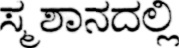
ಸ್ಮಶಾನದಲ್ಲಿ
